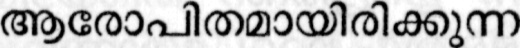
ആരോപിതമായിരിക്കുന്ന
